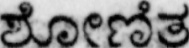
ಶೋಣಿತ
